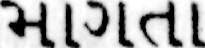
માગતા
